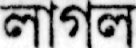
লাগল
